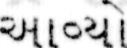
આવ્યો
